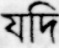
যদি
